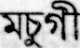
মচুগী
